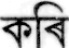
কৰি
